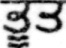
ਭੂਤ
